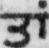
ਤਾਂ
